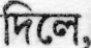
দিলে,
